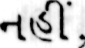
નહીં,
